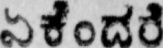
ಏಕೆಂದರೆ
